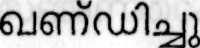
ഖണ്ഡിച്ചു
